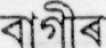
বাগীৰ
